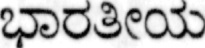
ಭಾರತೀಯ
